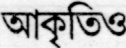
আকৃতিও
